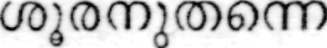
ശൂരനുതന്നെ
